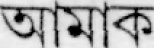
আমাক
